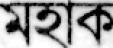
মহাক
